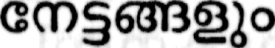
നേട്ടങ്ങളും
